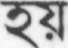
হয়
